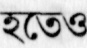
হতেও
